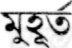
মুহূর্ত
